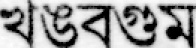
খঙবগুম
